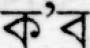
ক'ব
